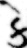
કે
